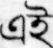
এই
